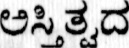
ಅಸ್ತಿತ್ವದ
